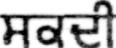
ਸਕਦੀ
